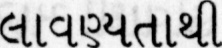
લાવણ્યતાથી
